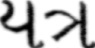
યત્ર
